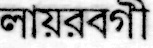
লায়রবগী
